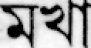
মখা
